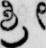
ಶ್ರೀ
